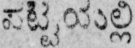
ಪಟ್ಟಿಯಲ್ಲಿ
